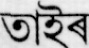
তাইৰ
